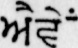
ਐਵੇਂ
